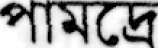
পামদ্রে
